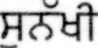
ਸਨੁੱਖੀ
